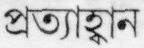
প্ৰত্যাহ্বান
